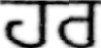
ਹਰ
